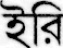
ইরি
